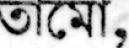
তামো,
